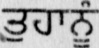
ਤੁਹਾਨੂੰ
